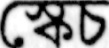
স্কেচ
